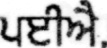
ਪਈਐ,
